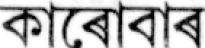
কাৰোবাৰ
